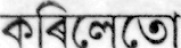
কৰিলেতো
